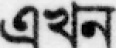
এখন
